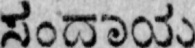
ಸಂದಾಯ
